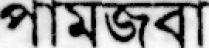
পামজবা
